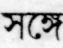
সঙ্গে
